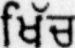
ਖਿੱਚ
